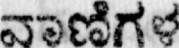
ವಾಣಿಗಳ
